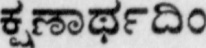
ಕ್ಷಣಾರ್ಥದಿಂ
